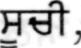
ਸੂਚੀ,
